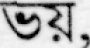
ভয়,
